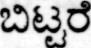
ಬಿಟ್ಟರೆ
